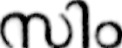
സിം
